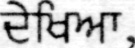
ਦੇਖਿਆ,
